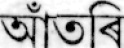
আঁতৰি
